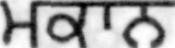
ਮਕਾਨ
